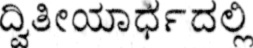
ದ್ವಿತೀಯಾರ್ಧದಲ್ಲಿ
